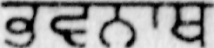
ਭਵਨਾਥ
